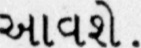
આવશે.
